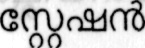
സ്റ്റേഷന്‍
